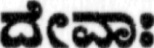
ದೇವಾಃ
